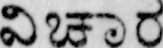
ವಿಚಾರ
